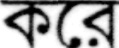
করে
